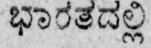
ಭಾರತದಲ್ಲಿ
